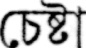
চেষ্টা
